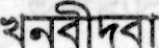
খনবীদবা
